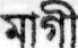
মাগী
